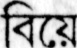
বিয়ে
